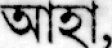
আহা,
